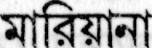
মারিয়ানা
